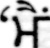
'ਮੈਂ
